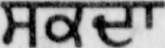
ਸਕਦਾ
